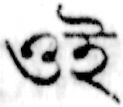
ওই
